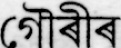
গৌৰীৰ
